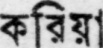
করিয়া
